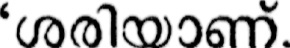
‘ശരിയാണ്.
